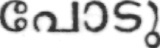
പോടു
